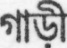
গাড়ী
